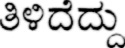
ತಿಳಿದೆದ್ದು
